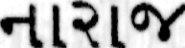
નારાજ
